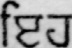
ਇਹ
